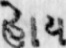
હોય
